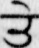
ਤੇ
